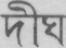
দীঘ
